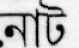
নোট
